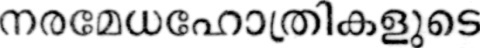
നരമേധഹോത്രികളുടെ
